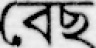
বেছ
